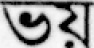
ভয়
